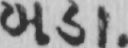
બડા.
